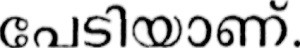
പേടിയാണ്.
